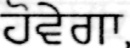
ਹੋਵੇਗਾ,
